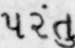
પરંતુ
